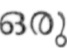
ഒരു
